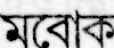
মবোক
